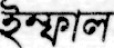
ইম্ফাল
